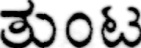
ತುಂಟ
